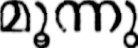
മൂന്നു
